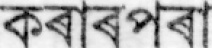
কৰাৰপৰা
